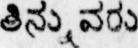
ತಿನ್ನುವರು
